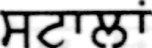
ਸਟਾਲਾਂ
